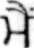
ਮੈਂ
